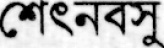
শেৎনবসু
